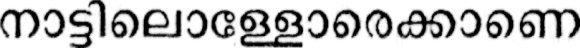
നാട്ടിലൊള്ളോരെക്കാണെ
